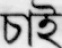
চাই
